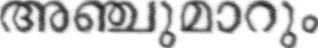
അഞ്ചുമാറും
